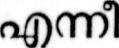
എന്നീ
